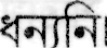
ধন্যনি।
